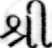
શ્રી
